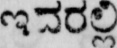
ಇದರಲ್ಲಿ
